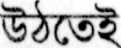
উঠতেই
